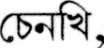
চেনখি,
